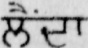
ਲੈਂਦਾ
